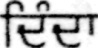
ਦਿੰਦਾ
